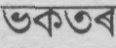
ভকতৰ
